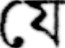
যে
